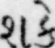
શકે
